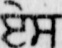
ਏਸ
